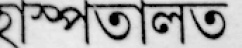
হাস্পতালত
